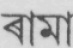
ৰামা
